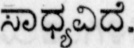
ಸಾಧ್ಯವಿದೆ.
